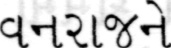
વનરાજને
